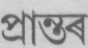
প্ৰান্তৰ
